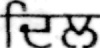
ਦਿਲ
